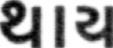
થાય
